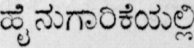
ಹೈನುಗಾರಿಕೆಯಲ್ಲಿ
